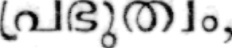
പ്രഭുത്വം,
